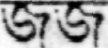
জজ
